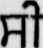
ਸੀ
